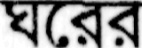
ঘরের
